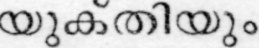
യുക്തിയും
